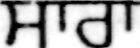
ਸਾਰਾ
